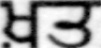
ਖ਼ਤ
